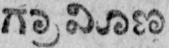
ಗ್ರಾಮೀಣ
